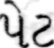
પેટ
